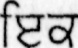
ਇਕ
